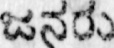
ಜನರು
